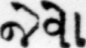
જેવો
